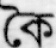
কৈ
